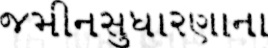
જમીનસુધારણાના
